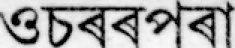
ওচৰৰপৰা
